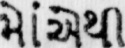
મોંએથી
